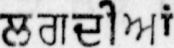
ਲਗਦੀਆਂ
